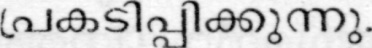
പ്രകടിപ്പിക്കുന്നു.
